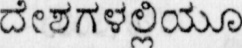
ದೇಶಗಳಲ್ಲಿಯೂ
